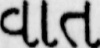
વાત
